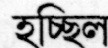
হচ্ছিল
